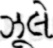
ઝૂલે
